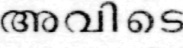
അവിടെ
